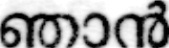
ഞാന്‍
